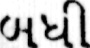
બધી
